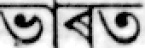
ভাৰত
